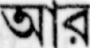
আর
